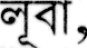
লূবা,
